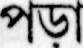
পড়া
